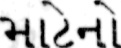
માટેનો
